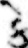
કે
